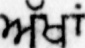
ਅੱਖਾਂ
